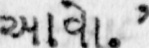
આવો.'
